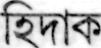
হিদাক
